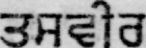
ਤਸਵੀਰ
